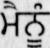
ਮੈਨੂੰ
